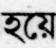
হয়ে
